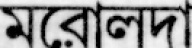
মরোলদা
